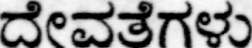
ದೇವತೆಗಳು
